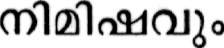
നിമിഷവും
